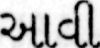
આવી
